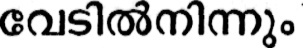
വേടില്‍നിന്നും
